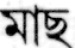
মাছ
